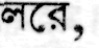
লৈরে,
